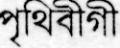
পৃথিবীগী
